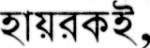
হায়রকই,
